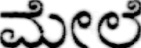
ಮೇಲೆ
